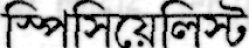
স্পিসিয়েলিস্ট
